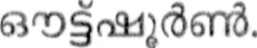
ഔട്ട്ഷൂര്‍ണ്‍.
